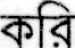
করি
